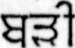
ਬੜੀ
